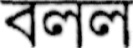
বলল
